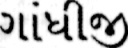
ગાંધીજી
